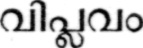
വിപ്ലവം
